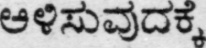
ಅಳಿಸುವುದಕ್ಕೆ
